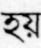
হয়
